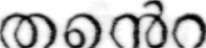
തന്റെ
